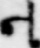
ન
